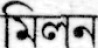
মিলন
